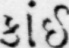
કાંઈ
